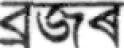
ব্রজৰ
